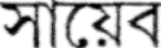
সায়েব
